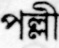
পল্লী
